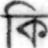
কি
